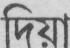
দিয়া
